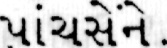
પાંચસેને.
